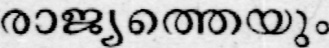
രാജ്യത്തെയും
